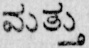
ಮತ್ತು
